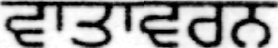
ਵਾਤਾਵਰਨ
